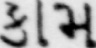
કામ
